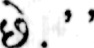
છે."
